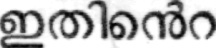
ഇതിന്റെ
